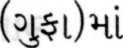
(ગુફા)માં
